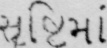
સૃષ્ટિમાં
